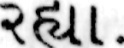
રહ્યા.
